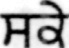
ਸਕੇ
